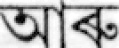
আৰু
